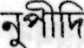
নুপীদি
